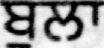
ਬੁਲਾ
